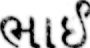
ભાઈ
